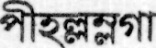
পীহল্লম্লগা
